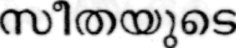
സീതയുടെ
